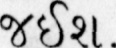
જઈશ.
